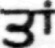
ਤਾਂ
